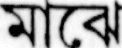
মাঝে
